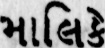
માલિકે
